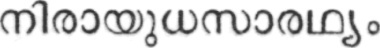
നിരായുധസാരഥ്യം
